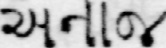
અનીજ
